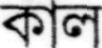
কাল
